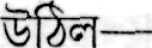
উঠিল-
